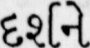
દર્શને
